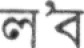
ল'ব
